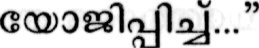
യോജിപ്പിച്ച്...”
